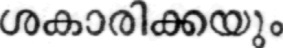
ശകാരിക്കയും
